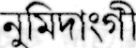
নুমিদাংগী
